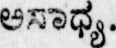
ಅಸಾಧ್ಯ.
